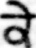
ਕੇ
